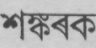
শঙ্কৰক
